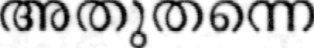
അതുതന്നെ
